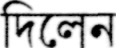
দিলেন
